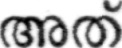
അത്
